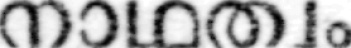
നാഥത്വം
